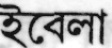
ইবেলা
